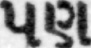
પણ
